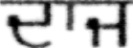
ਦਾਜ
